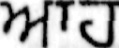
ਆਹ
